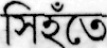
সিহঁতে
